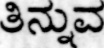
ತಿನ್ನುವ
